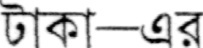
টাকা–এর
